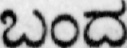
ಬಂದ
